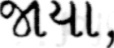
જાયા,
